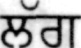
ਲੱਗ
